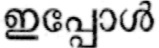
ഇപ്പോള്‍
